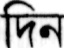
দিন
